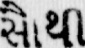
સૌથી
